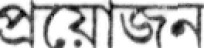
প্ৰয়োজন
